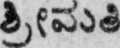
ಶ್ರೀಮತಿ
